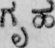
ಗೃಹ
